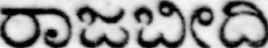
ರಾಜಬೀದಿ
